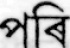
পৰি
